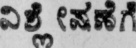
ವಿಶ್ಲೇಷಣೆಗೆ
